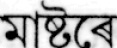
মাষ্টৰে
